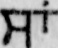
ਸਾਂ
